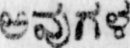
ಅವುಗಳ
